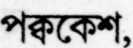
পক্ককেশ,
